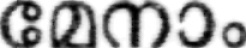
മേനാം
